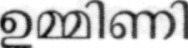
ഉമ്മിണി
